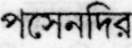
পসেনদির
